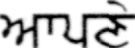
ਆਪਣੇ
